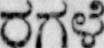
ರಗಳೆ
